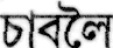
চাবলৈ
